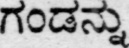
ಗಂಡನ್ನು
